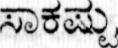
ಸಾಕಷ್ಟು
